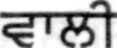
ਵਾਲੀ
